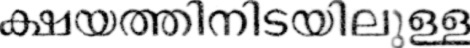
ക്ഷയത്തിനിടയിലുള്ള
